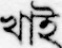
খাই
